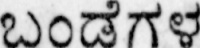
ಬಂಡೆಗಳ
